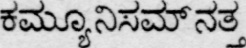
ಕಮ್ಯೂನಿಸಮ್‌ನತ್ತ
